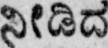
ನೀಡಿದ
